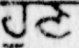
ਹੁਣ
